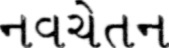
નવચેતન
